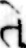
તે
